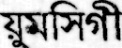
য়ুমসিগী
